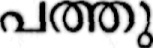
പത്തു
